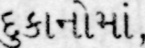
દુકાનોમાં,
